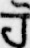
ਹੋ
